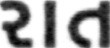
રાત
